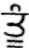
ਤੂੰ
